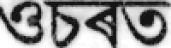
ওচৰত
